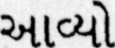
આવ્યો
